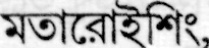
মতারোইশিং,
